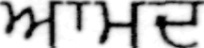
ਆਮਦ
